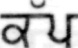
ਕੱਪ
